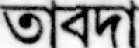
তাবদা
